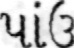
પાંઉ
